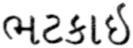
ભટકાઈ
